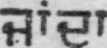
ਜਾਂਦਾ
